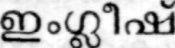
ഇംഗ്ലീഷ്
